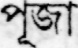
পূজা
